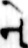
ને
